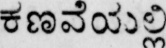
ಕಣವೆಯಲ್ಲಿ
